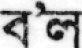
ব'ল
